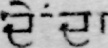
ਦੇਂਦਾ
